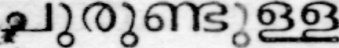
ചുരുണ്ടുള്ള
